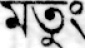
মতুং
